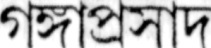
গঙ্গাপ্রসাদ
